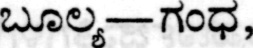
ಬೂಲ್ಯ-ಗಂಧ,
